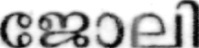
ജോലി
